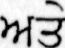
ਅਤੇ
